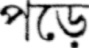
পড়ে
